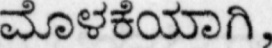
ಮೊಳಕೆಯಾಗಿ,
